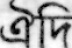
ঐদি
